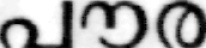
പൌര
